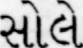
સોલે
